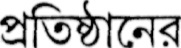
প্রতিষ্ঠানের
